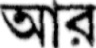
আর
